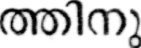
ത്തിനു
